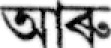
আৰু
